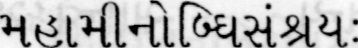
મહામીનોબ્ધિસંશ્રયઃ
